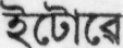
ইটোৱে
